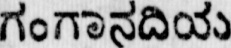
ಗಂಗಾನದಿಯ
